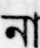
না
